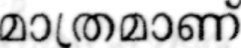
മാത്രമാണ്
